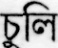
চুলি
